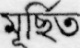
মূর্ছিত
